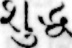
શુદ્ધ
